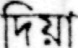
দিয়া
